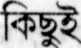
কিছুই
